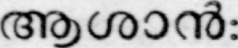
ആശാന്‍:
